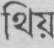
থিয়
